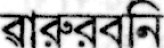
ৱারুরবনি
